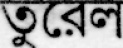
তুরেল
